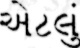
એટલું
